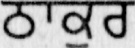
ਠਾਕੁਰ
